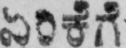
ಏರಿಕೆಗೆ
